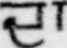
ਦਾ
